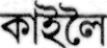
কাইলৈ
